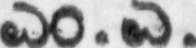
ಎಂ.ಎ.
